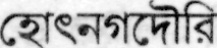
হোৎনগদৌরি
